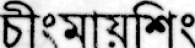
চীংমায়শিং
